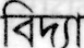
বিদ্যা
